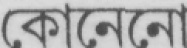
কোনেনো
